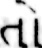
તો
